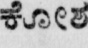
ಕೋಶ
